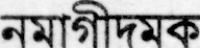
নমাগীদমক
